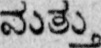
ಮತ್ತು
